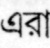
এরা
